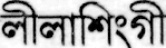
লীলাশিংগী
